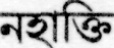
নহাক্তি
